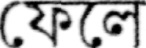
ফেলে
